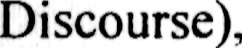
Discourse),
